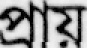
প্রায়
